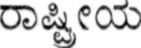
ರಾಷ್ಟ್ರೀಯ
